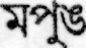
মপুঙ
